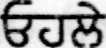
ਓਹਲੇ
